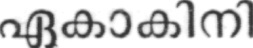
ഏകാകിനി
